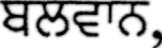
ਬਲਵਾਨ,
